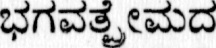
ಭಗವತ್ಪ್ರೇಮದ
